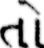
તો
